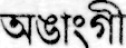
অঙাংগী
